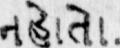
નહોતો.
